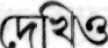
দেখিও
